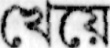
খেয়ে
